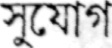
সুযোগ
